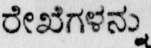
ರೇಖೆಗಳನ್ನು
